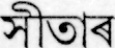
সীতাৰ
